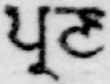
ਪ੍ਰਣ
